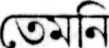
তেমনি
